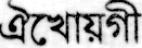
ঐখোয়গী
